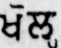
ਖੋਲ੍ਹ
